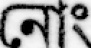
নোং
